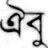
ঐবু
